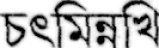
চৎমিন্নখি
